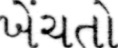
ખેંચતો
